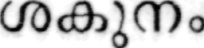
ശകുനം
